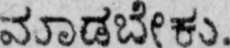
ಮಾಡಬೇಕು.
